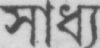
সাধ্য
